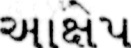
આક્ષેપ
